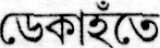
ডেকাহঁতে
